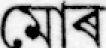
মোৰ
